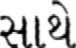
સાથે
